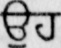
ਉਹ
